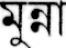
মুন্না
